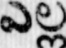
ಎಲ್ಲ
